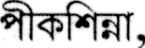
পীকশিন্না,
